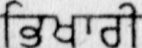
ਭਿਖਾਰੀ
